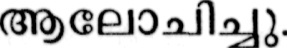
ആലോചിച്ചു.
